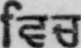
ਵਿਚ
